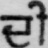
ਦੀ
